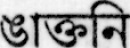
ঙাক্তনি
